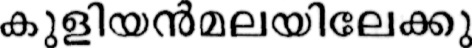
കുളിയന്‍മലയിലേക്കു
